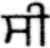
ਸੀ
